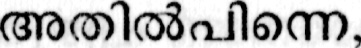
അതില്‍പിന്നെ,
